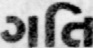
ગતિ
